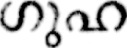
ഗുഹ
